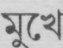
মুখে
